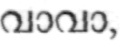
വാവാ,
